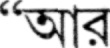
“আর
